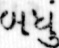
બધું
